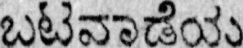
ಬಟವಾಡೆಯ
